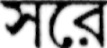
সরে
